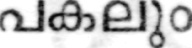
പകലും
